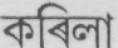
কৰিলা
